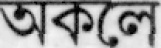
অকলে
